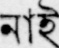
নাই
